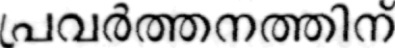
പ്രവര്‍ത്തനത്തിന്
